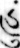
હું
